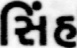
સિંહ
